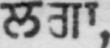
ਲਗਾ,
